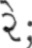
રે;
